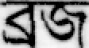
ব্রজ
